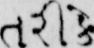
તરીકે
